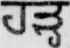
ਹੜ੍ਹ
